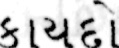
કાયદો
